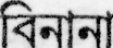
বিনানা
